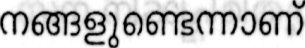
നങ്ങളുണ്ടെന്നാണ്
